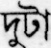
দুটা
